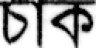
চাক
